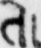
તો
